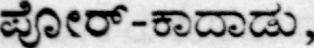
ಪೋರ್-ಕಾದಾಡು,
